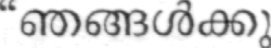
"ഞങ്ങള്‍ക്കു
